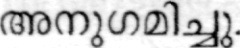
അനുഗമിച്ചു.
